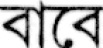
বাবে
